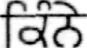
ਕਿੰਨੇ
